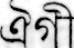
ঐগী
